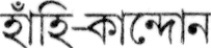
হাঁহি-কান্দোন
